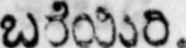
ಬರೆಯಿರಿ.
